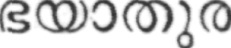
ഭയാതുര
